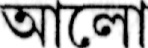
আলো
